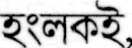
হংলকই,
